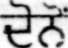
ਦੋਨੋਂ
